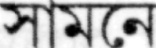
সামনে
